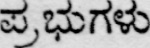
ಪ್ರಭುಗಳು
